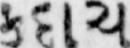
કદાચ
